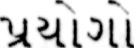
પ્રયોગો
